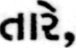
તારે,
